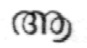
ആ
